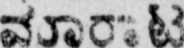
ಮಾರಾಟ
